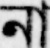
না
